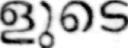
ളുടെ
